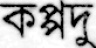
কপ্পদু
